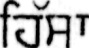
ਹਿੱਸਾ
